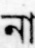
না
